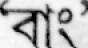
‘বাং’
